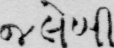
જલેબી
